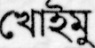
খোইমু
